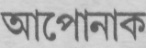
আপোনাক
